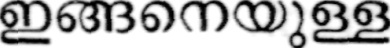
ഇങ്ങനെയുള്ള
